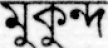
মুকুন্দ
